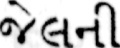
જેલની
